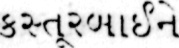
કસ્તૂરબાઈને
